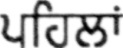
ਪਹਿਲਾਂ
